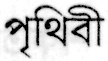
পৃথিবী
